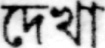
দেখা
